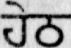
ਹੇਠ
